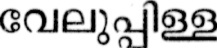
വേലുപ്പിള്ള
